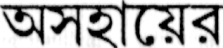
অসহায়ের
